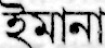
ইমানা
